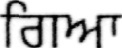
ਗਿਆ
